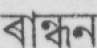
ৰান্ধন
